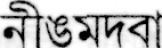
নীঙমদবা
